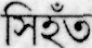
সিহঁত
